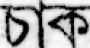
চাক
